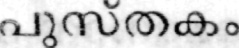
പുസ്തകം
